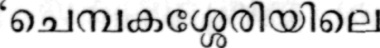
'ചെമ്പകശ്ശേരിയിലെ
